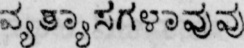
ವ್ಯತ್ಯಾಸಗಳಾವುವು
